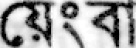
য়েংবা
